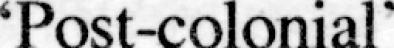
‘Post-colonial’
